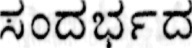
ಸಂದರ್ಭದ
